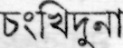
চংখিদুনা
